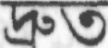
দ্রুত
